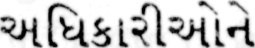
અધિકારીઓને
